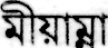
মীয়াম্না
